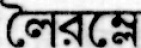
লৈরম্লে
